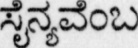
ಸೈನ್ಯವೆಂಬ
